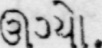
ઊગ્યો.
